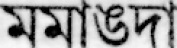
মমাঙদা
